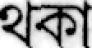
থকা
